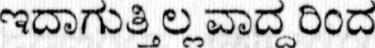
ಇದಾಗುತ್ತಿಲ್ಲವಾದ್ದರಿಂದ
